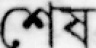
শেষ
